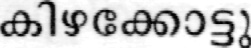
കിഴക്കോട്ടു
